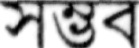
সম্ভব
